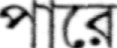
পারে
